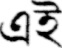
এই
